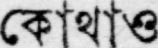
কোথাও
